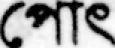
পোৎ
